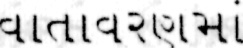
વાતાવરણમાં
